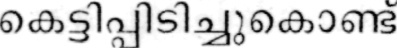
കെട്ടിപ്പിടിച്ചുകൊണ്ട്
